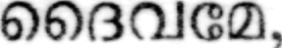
ദൈവമേ,
